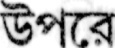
উপরে
